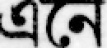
এনে
